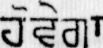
ਹੋਵੇਗਾ
